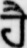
ਹੈ
